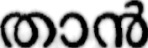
താന്‍
